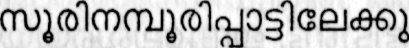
സൂരിനമ്പൂരിപ്പാട്ടിലേക്കു
